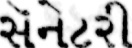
સૅનેટરી
